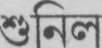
শুনিল
